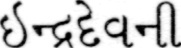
ઇન્દ્રદેવની
